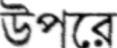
উপরে
